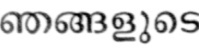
ഞങ്ങളുടെ
